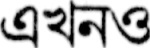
এখনও
